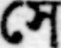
সে
